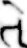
તે
